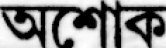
অশোক
